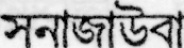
সনাজাউবা
